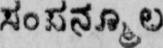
ಸಂಪನ್ಮೂಲ
